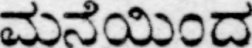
ಮನೆಯಿಂದ
